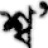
শ্ব'
